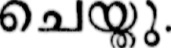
ചെയ്തു.
